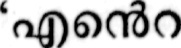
‘എന്റെ
